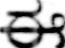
ಈ
